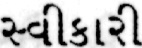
સ્વીકારી
